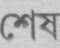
শেষ
